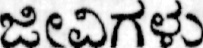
ಜೀವಿಗಳು
